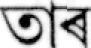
তাৰ
